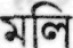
মলি
